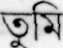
তুমি
